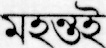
মহন্তই
